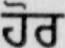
ਹੋਰ
